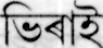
ভিৰাই
